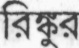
রিঙ্কুর
